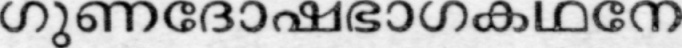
ഗുണദോഷഭാഗകഥനേ
